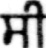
ਸੀ
